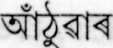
আঁঠুৱাৰ
